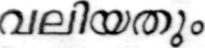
വലിയതും
